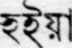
হইয়া
